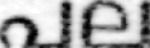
പല
